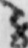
કે
